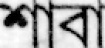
শাবা
